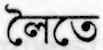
লৈতে
